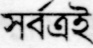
সর্বত্রই
